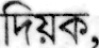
দিয়ক,
